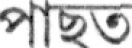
পাছত
